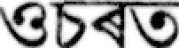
ওচৰত
